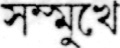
সম্মুখে
